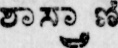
ಶಾಸ್ತ್ರಾಣಿ
